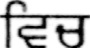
ਵਿਚ
